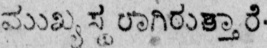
ಮುಖ್ಯಸ್ಥರಾಗಿರುತ್ತಾರೆ.
